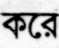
করে
